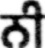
ਨੀ
